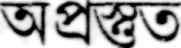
অপ্রস্তুত
